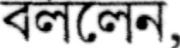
বললেন,
